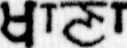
ਖਾਣਾ
